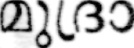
മുദ്രാ
